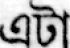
এটা
